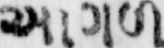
આગળ
